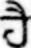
ਹੈ
